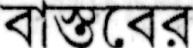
বাস্তবের
